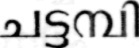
ചട്ടമ്പി
